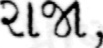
રાજા,
